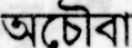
অচৌবা
